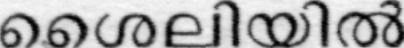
ശൈലിയില്‍
